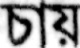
চায়
